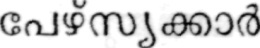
പേഴ്സ്യക്കാര്‍
